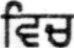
ਵਿਚ
